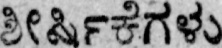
ಶೀರ್ಷಿಕೆಗಳು
